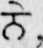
ਨੇ,
